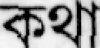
কথা
